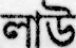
লাউ
